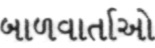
બાળવાર્તાઓ
